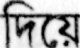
দিয়ে
